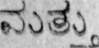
ಮತ್ತು
